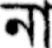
না
